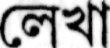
লেখা
